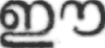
ഈ
